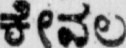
ಕೇವಲ
